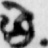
છે.
